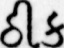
ઠીક
